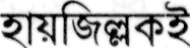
হায়জিল্লকই
